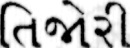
તિજોરી
